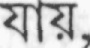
যায়,
